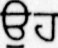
ਉਹ
